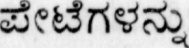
ಪೇಟೆಗಳನ್ನು
